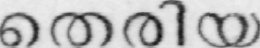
തെരിയ
